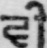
ਵੀ
